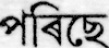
পৰিছে
